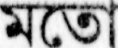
মতো
